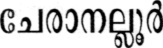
ചേരാനല്ലൂര്‍
